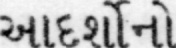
આદર્શોનો
